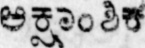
ಅಕ್ಷಾಂಶಿಕ
